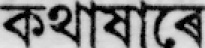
কথাষাৰে
